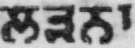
ਲੜਨਾ
